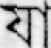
যা
